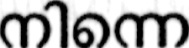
നിന്നെ
